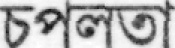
চপলতা
